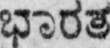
ಭಾರತ
